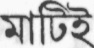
মাটিই
